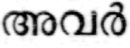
അവര്‍
